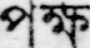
পক্ষ
